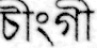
চীংগী
